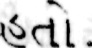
હતો.
